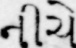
નીચે
